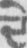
ਦੇ
